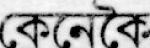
কেনেকৈ
